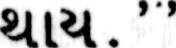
થાય."
